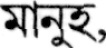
মানুহ,
